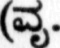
(ವೃ.
